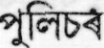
পুলিচৰ
